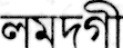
লমদগী
